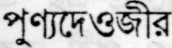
পুণ্যদেওজীর
